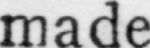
made
